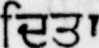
ਦਿਤਾ
